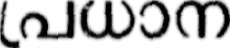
പ്രധാന
